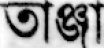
তাঞ্জা
